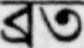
ব্রত
